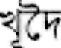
খূদৈ
